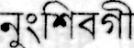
নুংশিবগী
